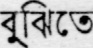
বুঝিতে
